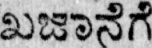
ಖಜಾನೆಗೆ
